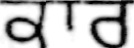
ਕਾਰ
